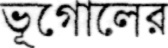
ভূগোলের
